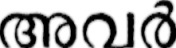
അവര്‍
